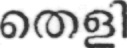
തെളി
